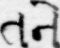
તને
